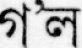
গ'ল
